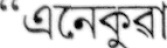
"এনেকুৱা
